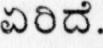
ಏರಿದೆ.
